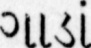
ગાડાં
